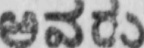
ಅವರು
